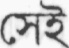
সেই
